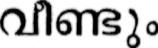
വീണ്ടും
